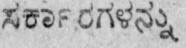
ಸರ್ಕಾರಗಳನ್ನು
